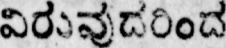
ವಿರುವುದರಿಂದ
